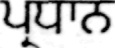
ਪ੍ਰਧਾਨ
